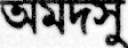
অমদসু
